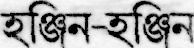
হঞ্জিন-হঞ্জন
